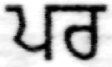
ਪਰ
